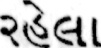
રહેલા
